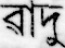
ৱাদু
